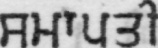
ਸਮਾਪਤੀ
